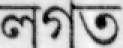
লগত
